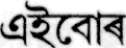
এইবোৰ
